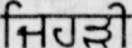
ਜਿਹੜੀ
